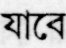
যাবে
